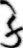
કે
